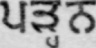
ਪੜ੍ਹਨ
